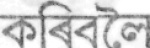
কৰিবলৈ
